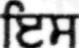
ਇਸ
